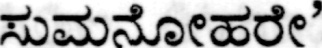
ಸುಮನೋಹರೇ'
